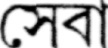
সেবা
